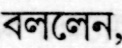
বললেন,
